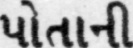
પોતાની
